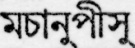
মচানুপীসু
